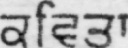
ਕਵਿਤਾ
